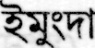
ইমুংদা
